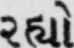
રહ્યો
